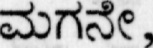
ಮಗನೇ,
